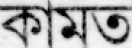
কামত
